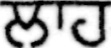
ਲਾਹ
